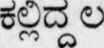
ಕಲ್ಲಿದ್ದಲ
